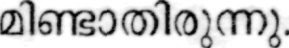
മിണ്ടാതിരുന്നു.
